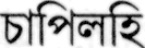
চাপিলহি
